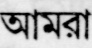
আমরা
